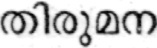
തിരുമന
